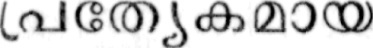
പ്രത്യേകമായ
